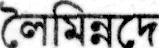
লৈমিন্নদে
